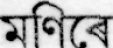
মণিৰে
